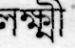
লক্ষ্মী
